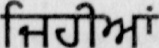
ਜਿਹੀਆਂ
